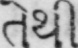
તેથી
